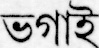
ভগাই
